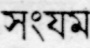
সংযম
